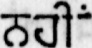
ਨਹੀਂ
